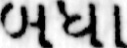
બધા
